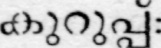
കുറുപ്പ്:
